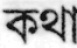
কথা
